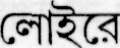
লোইরে
